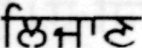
ਲਿਜਾਣ
